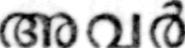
അവര്‍
